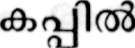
കപ്പില്‍
